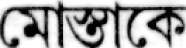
মোস্তাকে
